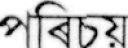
পৰিচয়
